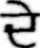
ਦੇ
